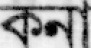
কনা
